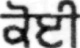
ਕੋਈ
